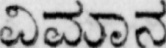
ವಿಮಾನ
